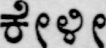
ಕೇಳೀ
